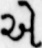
એ
